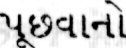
પૂછવાનો
